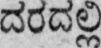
ದರದಲ್ಲಿ
